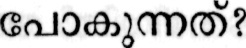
പോകുന്നത്?
